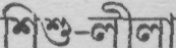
শিশু-লীলা
